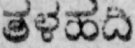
ತಳಹದಿ
